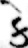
કે
